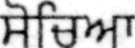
ਸੋਚਿਆ
